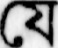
যে
